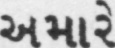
અમારે
